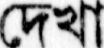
দেখা
